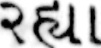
રહ્યા
